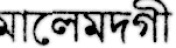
মালেমদগী
